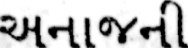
અનાજની
